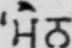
'ਮੈਨ
